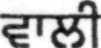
ਵਾਲੀ
